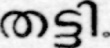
തട്ടി.
